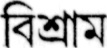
বিশ্রাম
